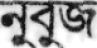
নুবুজ
